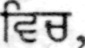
ਵਿਚ,
